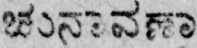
ಚುನಾವಣಾ
